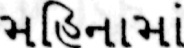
મહિનામાં
